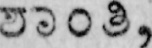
ಶಾಂತಿ,
